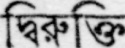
দ্বিরুক্তি
